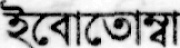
ইবোতোম্বা
